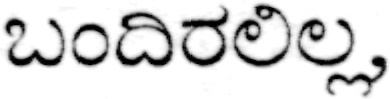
ಬಂದಿರಲಿಲ್ಲ,
